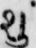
શું
